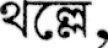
থল্লে,
